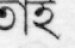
তাই
